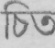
চিত
